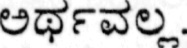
ಅರ್ಥವಲ್ಲ.
